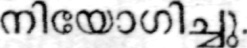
നിയോഗിച്ചു.
